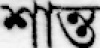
শান্ত
